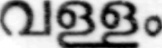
വള്ളം
